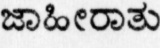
ಜಾಹೀರಾತು
